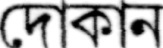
দোকান
